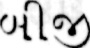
બીજી
